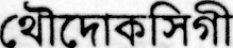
থৌদোকসিগী
